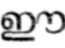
ഈ
